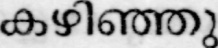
കഴിഞ്ഞു
